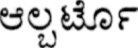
ಆಲ್ಬರ್ಟೊ
